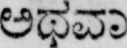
ಅಥವಾ
